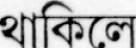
থাকিলে
